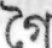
গৈ
